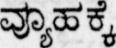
ವ್ಯೂಹಕ್ಕೆ
